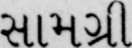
સામગ્રી
